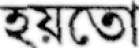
হয়তো
